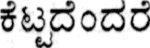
ಕೆಟ್ಟದೆಂದರೆ
